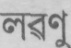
লৱণু
